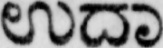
ಉದಾ
